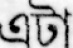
এটা
